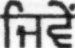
ਜਿਵੇਂ
